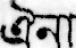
ঐনা
